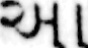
આ
